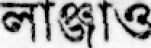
লাঞ্জাও
